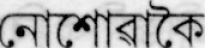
নোশোৱাকৈ
